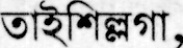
তাইশিল্লগা,
